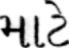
માટે
